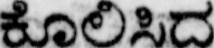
ಕೊಲಿಸಿದ
